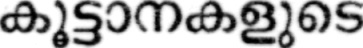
കൂട്ടാനകളുടെ
